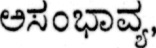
ಅಸಂಭಾವ್ಯ,
